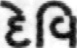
દેવિ
